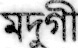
মদুগী
